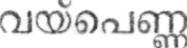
വയ്പെണ്ണ
